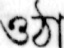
ওঠা
